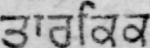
ਤਾਰਕਿਕ
